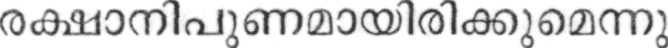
രക്ഷാനിപുണമായിരിക്കുമെന്നു
